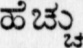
ಹೆಚ್ಚು
